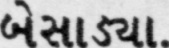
બેસાડ્યા.
